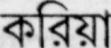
করিয়া
